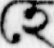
হে
